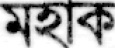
মহাক
